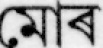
মোৰ
